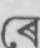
ৰে
